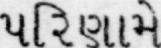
પરિણામે
